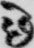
છે
